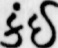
કંઇ
